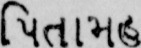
પિતામહ
